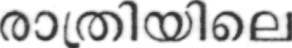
രാത്രിയിലെ
